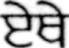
ਏਥੇ
